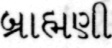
બ્રાહ્મણી
